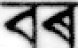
বৰ
